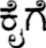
ಕೈಗೆ
